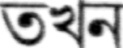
তখন
